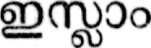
ഇസ്ളാം
